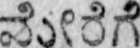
ಮೇರೆಗೆ
